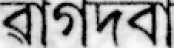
ৱাগদবা
